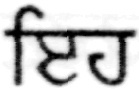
ਇਹ
